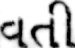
વતી
